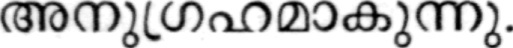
അനുഗ്രഹമാകുന്നു.
